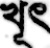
খূৎ
